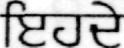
ਇਹਦੇ
